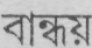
বান্ধয়
